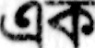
এক
